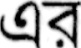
এর
